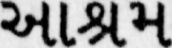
આશ્રમ
